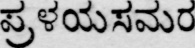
ಪ್ರಳಯಸಮರ
